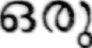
ഒരു
